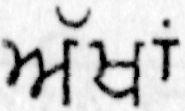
ਅੱਖਾਂ
